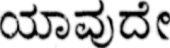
ಯಾವುದೇ
